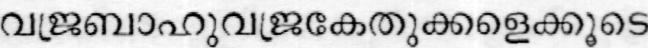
വജ്രബാഹുവജ്രകേതുക്കളെക്കൂടെ
